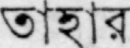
তাহার
